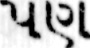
પણ
